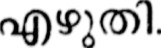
എഴുതി.
